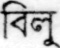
বিলু
